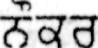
ਨੌਕਰ
